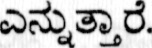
ಎನ್ನುತ್ತಾರೆ.
